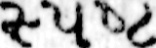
સ્પષ્ટ
